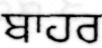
ਬਾਹਰ
